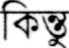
কিন্তু
